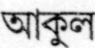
আকুল
